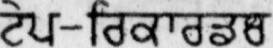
ਟੇਪ-ਰਿਕਾਰਡਰ
